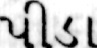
પીડા
